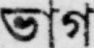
ভাগ
